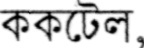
ককটেল,
